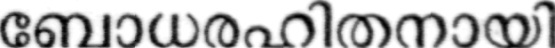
ബോധരഹിതനായി
